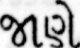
જાણે
